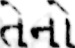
તેનો
